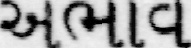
અભાવ
